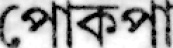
পোকপা
